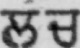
ਲਚ
